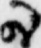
જે
